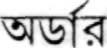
অর্ডার
